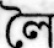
লৈ
